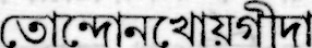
তোন্দোনখোয়গীদা
